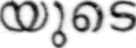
യുടെ
